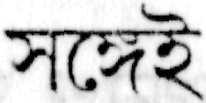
সঙ্গেই
